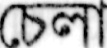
চেলা
